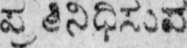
ಪ್ರತಿನಿಧಿಸುವ
